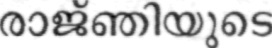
രാജ്ഞിയുടെ
